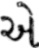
એ
